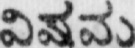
ವಿಷಮ
